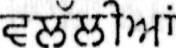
ਵਲੱਲੀਆਂ
